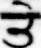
ਤੇ
